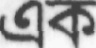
এক
